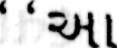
"આ
